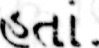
હતાં.
